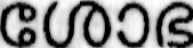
ശോഭ
